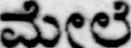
ಮೇಲೆ
